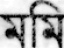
মমি
